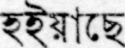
হইয়াছে
